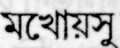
মখোয়সু
